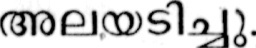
അലയടിച്ചു.
